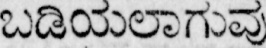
ಬಡಿಯಲಾಗುವು
